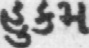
હુકમ
